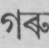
গৰু
